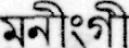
মনীংগী
